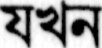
যখন
